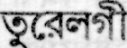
তুরেলগী
